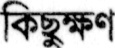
কিছুক্ষণ
